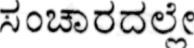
ಸಂಚಾರದಲ್ಲೇ
